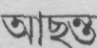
আছন্ত
